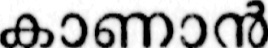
കാണാന്‍
